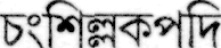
চংশিল্লকপদি
